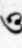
ও
